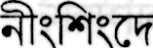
নীংশিংদে
